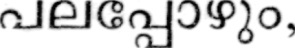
പലപ്പോഴും,
